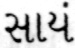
સાયં
